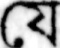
যে
